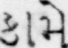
કામે
